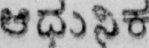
ಆಧುನಿಕ
